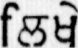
ਲਿਖੇ
